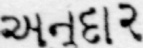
અનુદાર
